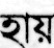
হায়
